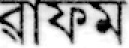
ৱাফম
